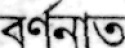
বর্ণনাত
